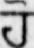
ਹੋ
